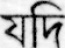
যদি
